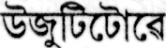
উজুটিটোৱে
